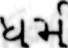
ધર્મ
